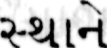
સ્થાને
